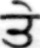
ਤੇ
